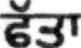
ਫੱਤਾ
